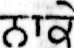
ਨਾਕੇ
